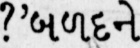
?'બળદને
